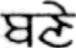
ਬਣੇ
